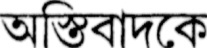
অস্তিবাদকে
